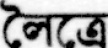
লৈত্রে
